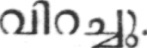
വിറച്ചു.
